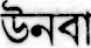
উনবা
